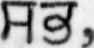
ਸਭ,
